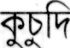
কুচুদি
